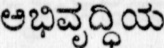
ಅಭಿವೃದ್ಧಿಯ
